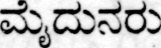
ಮೈದುನರು
